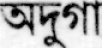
অদুগা
